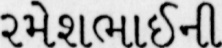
રમેશભાઈની
